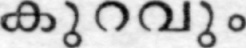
കുറവും
